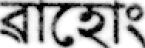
ৱাহোং
